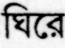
ঘিরে
